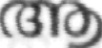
ആ
